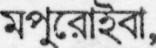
মপুরোইবা,
